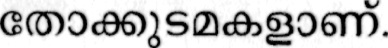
തോക്കുടമകളാണ്.
